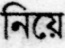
নিয়ে
